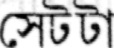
সেটটা
